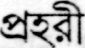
প্রহরী
